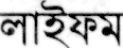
লাইফম
